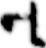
ન
